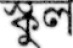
স্কুল
